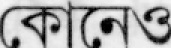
কোনেও
